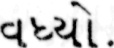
વધ્યો.
